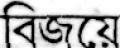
বিজয়ে
